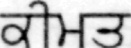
ਕੀਮਤ
